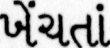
ખેંચતાં
